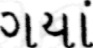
ગયાં
